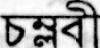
চম্লবী
